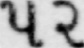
પર
